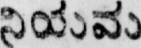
ನಿಯಮ
